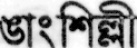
ঙাংশিল্লী
